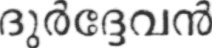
ദുര്‍ദ്ദേവന്‍
